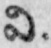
ವಿ.
